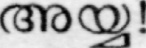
അയ്യ!
